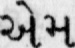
એમ
